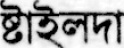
ষ্টাইলদা
